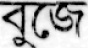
বুজে
